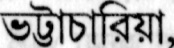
ভট্টাচারিয়া,
